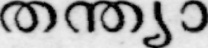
തന്ത്യാ
